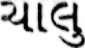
ચાલુ
